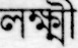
লক্ষ্মী
